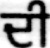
ਦੀ
